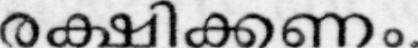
രക്ഷിക്കണം.
